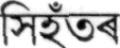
সিহঁতৰ
